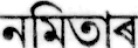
নমিতাৰ
